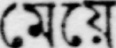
মেয়ে
